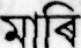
মাৰি
